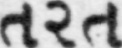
તરત
